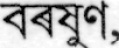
বৰষুণ,
